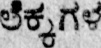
ಲೆಕ್ಕಗಳ
